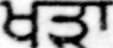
ਖੜਾ
